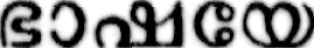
ഭാഷയേ
